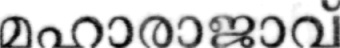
മഹാരാജാവ്
